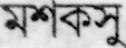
মশকসু
